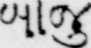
બાજુ
